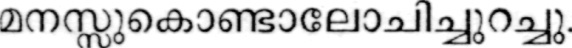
മനസ്സുകൊണ്ടാലോചിച്ചുറച്ചു.
